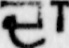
ਦਾ
